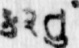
કરતું
